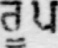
ਰੂਪ
